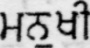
ਮਨੁਖੀ
